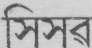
সিসৱ
